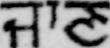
ਜਾਣ
